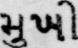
મુખી
